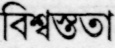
বিশ্বস্ততা
